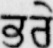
ਭਰੇ
